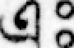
এঃ
